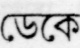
ডেকে
